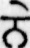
ਨੇ
